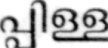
പ്പിള്ള
